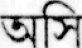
অসি
